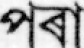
পৰা
